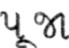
પૂજા
